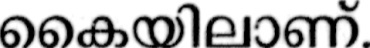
കൈയിലാണ്.
